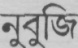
নুবুজি
